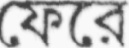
ফেরে
